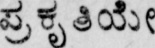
ಪ್ರಕೃತಿಯೇ
